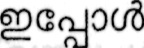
ഇപ്പോള്‍
